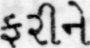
ફરીને
